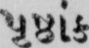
પૃષ્ઠાંક
